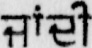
ਜਾਂਦੀ
